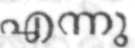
എന്നു
